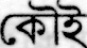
কৌই
